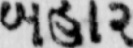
બહાર
